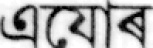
এযোৰ
